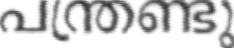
പന്ത്രണ്ടു
